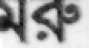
মরু
